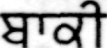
ਬਾਕੀ
